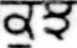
ਕੁਝ
